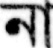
না
